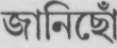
জানিছোঁ
